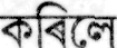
কৰিলে
